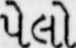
પેલો
